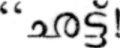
"ഛട്ട്!
